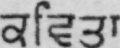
ਕਵਿਤਾ
